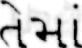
તેમાં
